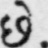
છે.
